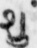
શું
